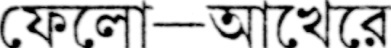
ফেলো–আখেরে
